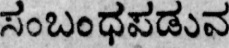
ಸಂಬಂಧಪಡುವ
